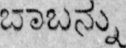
ಬಾಬನ್ನು
